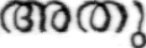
അതു
